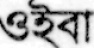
ওইবা
